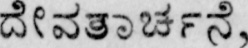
ದೇವತಾರ್ಚನೆ,
